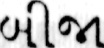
બીજા
